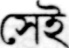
সেই
